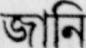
জানি
